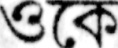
ওকে
